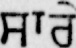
ਸਾਰੇ
